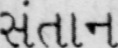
સંતાન
